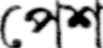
পেশ
